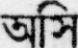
অসি
